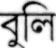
বুলি
